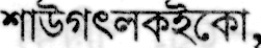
শাউগৎলকইকো,
